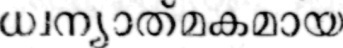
ധ്വന്യാത്മകമായ
